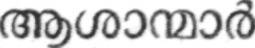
ആശാന്മാര്‍
